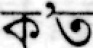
ক'ত
